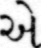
એ
